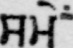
ਸਮੇਂ
